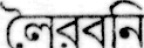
লৈরবনি
